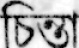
চিন্তা
